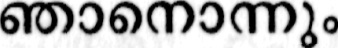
ഞാനൊന്നും
